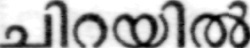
ചിറയില്‍
